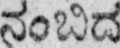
ನಂಬಿದ
